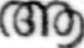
ആ
